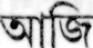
আজি
